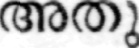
അതു
